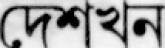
দেশখন
